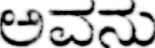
ಅವನು
